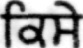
ਕਿਸੇ
